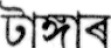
টাঙ্গাৰ
